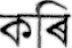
কৰি
